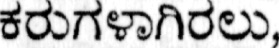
ಕರುಗಳಾಗಿರಲು,
